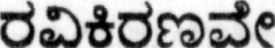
ರವಿಕಿರಣವೇ
